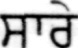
ਸਾਰੇ
